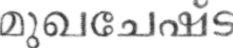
മുഖചേഷ്ട
